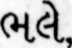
ભલે,
